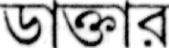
ডাক্তার
